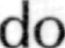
do
